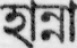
হান্না
